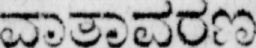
ವಾತಾವರಣ
